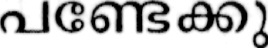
പണ്ടേക്കു
